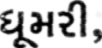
ધૂમરી,
